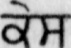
ਕੇਸ
